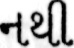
નથી
